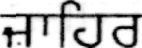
ਜ਼ਾਹਿਰ
